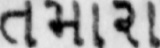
તમારા
